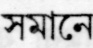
সমানে
